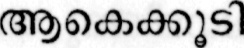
ആകെക്കൂടി
